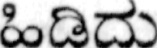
ಹಿಡಿದು
